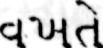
વખતે
